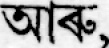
আৰু,
